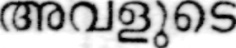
അവളുടെ
